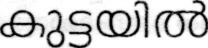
കുട്ടയില്‍
